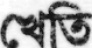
খেতি
